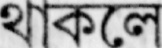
থাকলে
